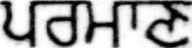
ਪਰਮਾਣ
